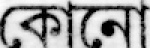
কোনো
